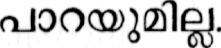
പാറയുമില്ല.
